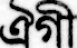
ঐগী
